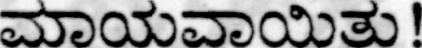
ಮಾಯವಾಯಿತು!
